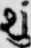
શું
